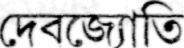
দেবজ্যোতি
